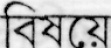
বিষয়ে
